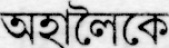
অহালৈকে
